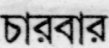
চারবার
